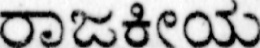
ರಾಜಕೀಯ
